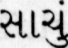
સાચું
